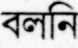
বলনি
